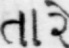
તારે
